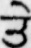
ਤੇ
